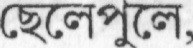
ছেলেপুলে,
